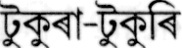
টুকুৰা-টুকুৰি
